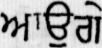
ਆਉਗੇ
